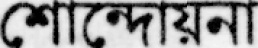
শোন্দোয়না
